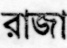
রাজা
